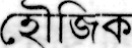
হৌজিক
